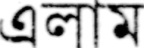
এলাম
